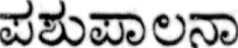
ಪಶುಪಾಲನಾ
